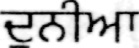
ਦੁਨੀਆ
